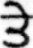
ਤੇ
